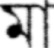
মা
